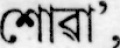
শোৱা',
